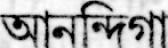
আনন্দিগা
